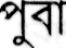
পুবা
